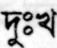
দুঃখ
